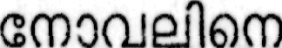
നോവലിനെ
